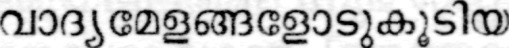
വാദ്യമേളങ്ങളോടുകൂടിയ
